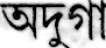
অদুগা
